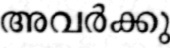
അവര്‍ക്കു
